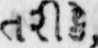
તરીકે,
